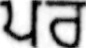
ਪਰ
